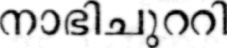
നാഭിചുററി
